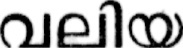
വലിയ
